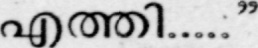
എത്തി....."
